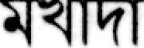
মখাদা
